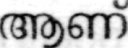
ആണ്
